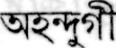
অহন্দুগী
